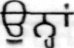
ਉਨ੍ਹਾਂ
